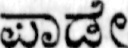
ಪಾಡೇ
